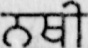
ਨਥੀ
